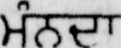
ਮੰਨਦਾ
